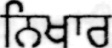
ਨਿਖਾਰ
